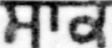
ਸਾਕ
